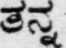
ತನ್ನ
